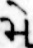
મે
